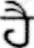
ਹੈ
